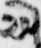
એ
